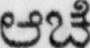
ಆಚೆ
